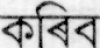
কৰিব
